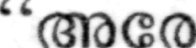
"അരേ
